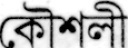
কৌশলী
